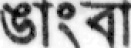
ঙাংবা
